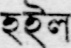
হইল
